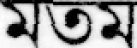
মতম
